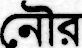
নৌর
